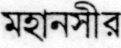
মহানসীর
